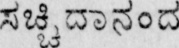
ಸಚ್ಚಿದಾನಂದ
